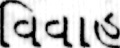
વિવાહ
